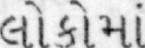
લોકોમાં
